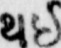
થઈ
